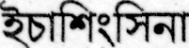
ইচাশিংসিনা
